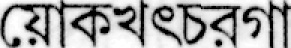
য়োকখৎচরগা
